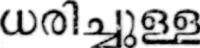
ധരിച്ചുള്ള
